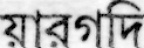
য়ারগদি
